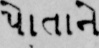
પોતાને
